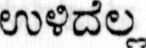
ಉಳಿದೆಲ್ಲ
